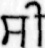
ਸੀ
